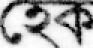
হেক
